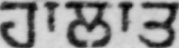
ਹਾਲਾਤ
